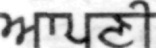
ਆਪਣੀ
